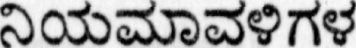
ನಿಯಮಾವಳಿಗಳ
